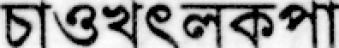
চাওখৎলকপা
